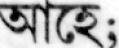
আহে;
